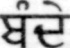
ਬੰਦੇ
